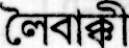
লৈবাক্কী
